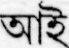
আই
